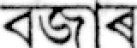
বজাৰ
